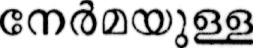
നേര്‍മയുള്ള
